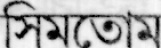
সিমতোম
